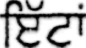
ਇੱਟਾਂ
